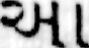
આ
